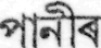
পানীৰ
